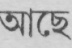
আছে
